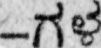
-ಗಳ
